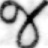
જ
